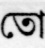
তো
